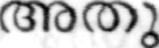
അതു
